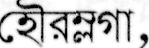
হৌরম্লগা,
